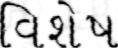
વિશેષ
